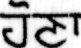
ਹੋਣਾ
